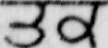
ਤਕ
